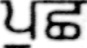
ਪੁਛ
